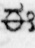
ಈ
